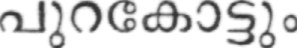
പുറകോട്ടും
